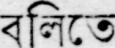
বলিতে
